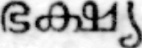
ഭക്ഷ്യ
